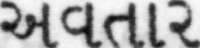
અવતાર
